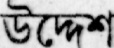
উদ্দেশ
